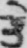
ਤੇ
